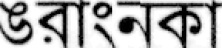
ঙরাংনকা
